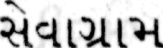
સેવાગ્રામ
